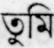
তুমি
